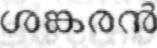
ശങ്കരന്‍
